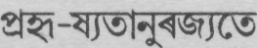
প্ৰহৃ-ষ্যতানুৰজ্যতে
